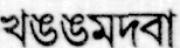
খঙঙমদবা
